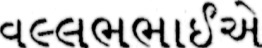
વલ્લભભાઈએ
